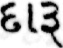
દારૂ
